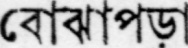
বোঝাপড়া
